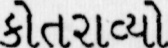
કોતરાવ્યો
